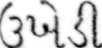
ઉખેડી
